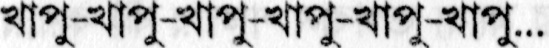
খাপু-খাপু-খাপু-খাপু-খাপু-খাপু...
